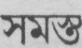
সমস্ত
